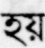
হয়
